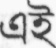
এই
